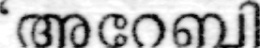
‘അറേബി
